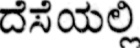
ದೆಸೆಯಲ್ಲಿ
